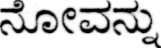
ನೋವನ್ನು
